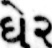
ઘેર
